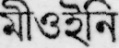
মীওইনি
